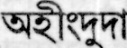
অহীংদুদা
